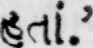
હતા.'
